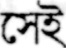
সেই
